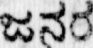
ಜನರ
